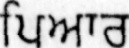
ਪਿਆਰ
